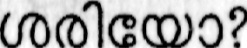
ശരിയോ?
